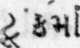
ટૂંકમાં
